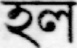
হল
